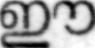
ഈ
